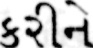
કરીને
